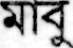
মাবু
